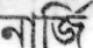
নার্জি
